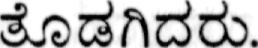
ತೊಡಗಿದರು.
